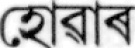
হোৱাৰ
